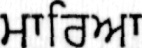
ਮਾਰਿਆ
